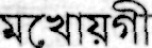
মখোয়গী
